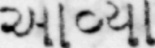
આવ્યા
